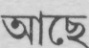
আছে
